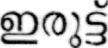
ഇരുട്ട്
